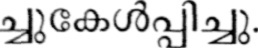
ച്ചുകേള്‍പ്പിച്ചു.
